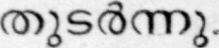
തുടര്‍ന്നു.
